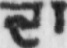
ਦਾ
